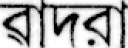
ৱাদরা
